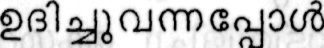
ഉദിച്ചുവന്നപ്പോള്‍
